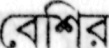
বেশির
